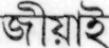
জীয়াই
